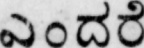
ಎಂದರೆ
